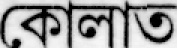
কোলাত
